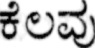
ಕೆಲವು
